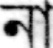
না
